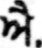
ਐ,
